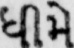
ધીમે
